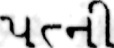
પત્ની
